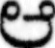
ಆ
